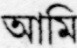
আমি
